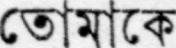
তোমাকে
